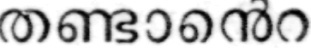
തണ്ടാന്റെ
